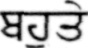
ਬਹੁਤੇ
